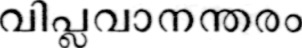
വിപ്ലവാനന്തരം
